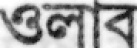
ওলাব
